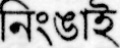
নিংঙাই
